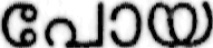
പോയ
